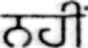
ਨਹੀਂ
